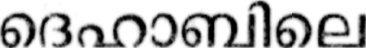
ദെഹാബിലെ
